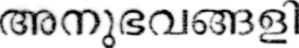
അനുഭവങ്ങളി
